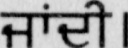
ਜਾਂਦੀ।
